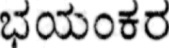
ಭಯಂಕರ
